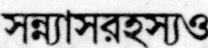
সন্ন্যাসরহস্যও
